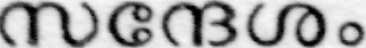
സന്ദേശം
